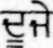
ਦੂਜੇ
